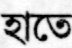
হাতে
